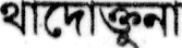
থাদোক্তুনা
